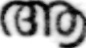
ആ
